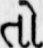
તો
